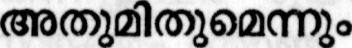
അതുമിതുമെന്നും
